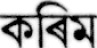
কৰিম
